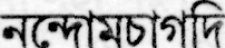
নন্দোমচাগদি
